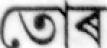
তোৰ
